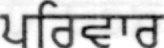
ਪਰਿਵਾਰ
